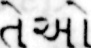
તેઓ
